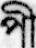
পী
